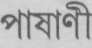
পাষাণী
